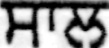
ਸਾਲ
